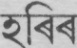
হৰিৰ
